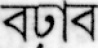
বঢ়াব
